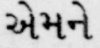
એમને
